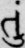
તું
